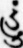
હું
